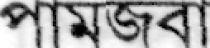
পামজবা
